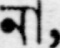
না,
